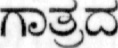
ಗಾತ್ರದ
